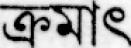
ক্রমাৎ
